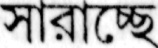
সারাচ্ছে
